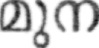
മുന
